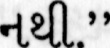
નથી."
